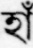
হাঁ
